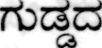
ಗುಡ್ಡದ
